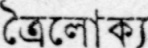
ত্রৈলোক্য
